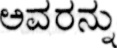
ಅವರನ್ನು
